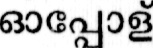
ഓപ്പോള്
